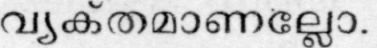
വ്യക്തമാണല്ലോ.
